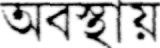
অবস্থায়
